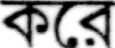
করে
